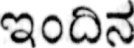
ಇಂದಿನ
